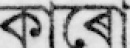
কাৰো
